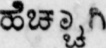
ಹೆಚ್ಚಾಗಿ
